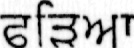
ਫੜਿਆ
